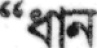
"ধান
